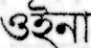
ওইনা
